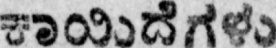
ಕಾಯಿದೆಗಳು
